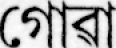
গোৱা
